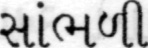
સાંભળી
